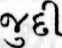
જુદી
